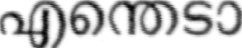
എന്തെടാ
